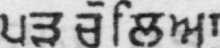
ਪੜਚੋਲਿਆ
